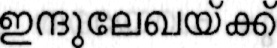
ഇന്ദുലേഖയ്ക്ക്
